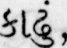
કાઢું,
